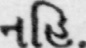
નહિ.
